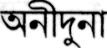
অনীদুনা
